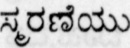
ಸ್ಮರಣೆಯು
